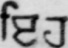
ਇਹ
